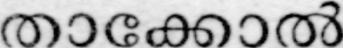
താക്കോല്‍
